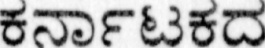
ಕರ್ನಾಟಕದ
